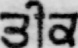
ਤੀਕ
